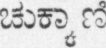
ಚುಕ್ಕಾಣಿ
